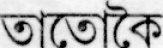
তাতোকৈ
